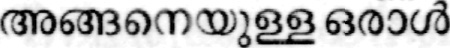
അങ്ങനെയുള്ളഒരാള്‍
